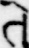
તે
